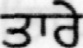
ਤਾਰੇ
